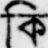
কি
